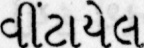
વીંટાયેલ
